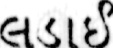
લડાઈ
